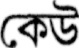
কেউ
